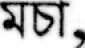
মচা,
